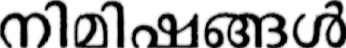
നിമിഷങ്ങള്‍
